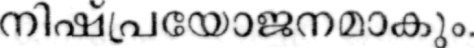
നിഷ്പ്രയോജനമാകും.
